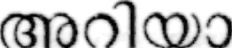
അറിയാ
